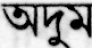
অদুম
